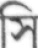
সি
